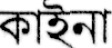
কাইনা
